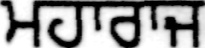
ਮਹਾਰਾਜ
